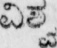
ವಿಶ್ವ
